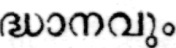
ദ്ധാനവും
